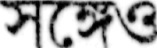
সঙ্গেও
